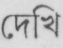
দেখি
